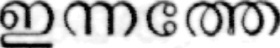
ഇന്നത്തേ
